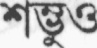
শম্ভুও
